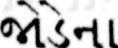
જોડેના
